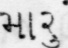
મારું
